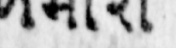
અમારા
